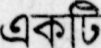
একটি
